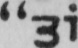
''ਤਾਂ
